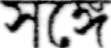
সঙ্গে
